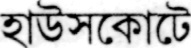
হাউসকোটে
